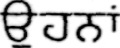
ਉਹਨਾਂ
